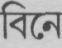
বিনে
